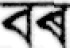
বৰ
